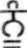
ਨੂੰ
